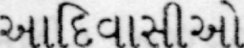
આદિવાસીઓ
